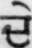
ਦੇ
